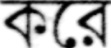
করে
